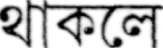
থাকলে
